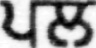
ਪਲ
